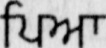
ਪਿਆ
